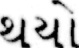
થયો
